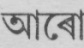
আৰো
